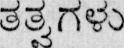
ತತ್ವಗಳು
